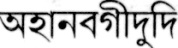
অহানবগীদুদি
